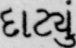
દાટ્યું
